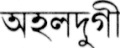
অহলদুগী
